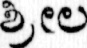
ಶ್ರೀಲ
